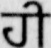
ਹੀ
